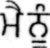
ਮੈਨੂੰ
